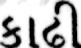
કાઢી
